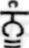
ਨੂੰ
